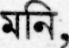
মনি,
